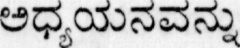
ಅಧ್ಯಯನವನ್ನು
